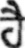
ਹੈ
